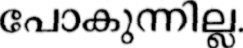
പോകുന്നില്ല.
